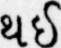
થઈ
